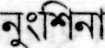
নুংশিনা
